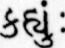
કહ્યું:
